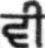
ਵੀ
